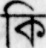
কি
